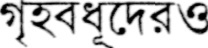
গৃহবধূদেরও
